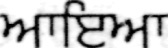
ਆਇਆ
